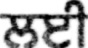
ਲਈ
